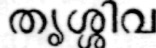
തൃശ്ശിവ
